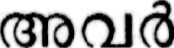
അവര്‍
